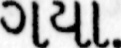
ગયા.
